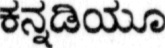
ಕನ್ನಡಿಯೂ
